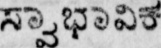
ಸ್ವಾಭಾವಿಕ
